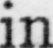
in
